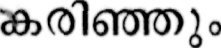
കരിഞ്ഞും
